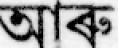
আৰু
